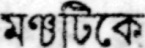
মঞ্চটিকে
